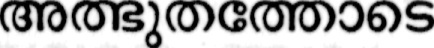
അത്ഭുതത്തോടെ
